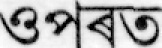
ওপৰত
